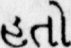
હતો.
